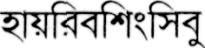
হায়রিবশিংসিবু
